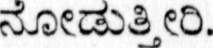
ನೋಡುತ್ತೀರಿ.
